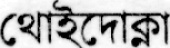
থোইদোক্না
